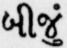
બીજું
